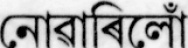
নোৱাৰিলোঁ
